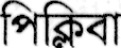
পিক্লিবা
